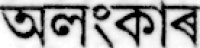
অলংকাৰ
